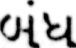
બંધ
